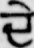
ਦੇ
